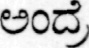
ಅಂದ್ರೆ
